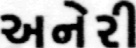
અનેરી
